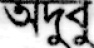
অদুবু
